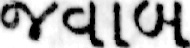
જવાબ
